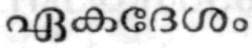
ഏകദേശം
